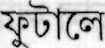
ফুটালে
